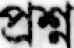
প্রশ্ন
